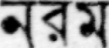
নরম
